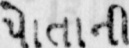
પોતાની
